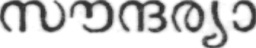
സൌന്ദര്യാ
